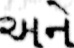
અને
